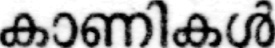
കാണികള്‍
